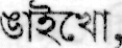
ঙাইখো,
